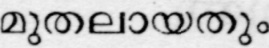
മുതലായതും
